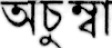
অচুম্বা
